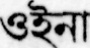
ওইনা
